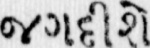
જગદીશે
